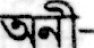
অনী-
